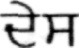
ਦੇਸ
